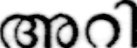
അറി
